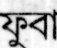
ফুবা
